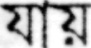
যায়
